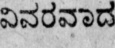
ವಿವರವಾದ
